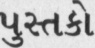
પુસ્તકો
